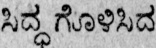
ಸಿದ್ಧಗೊಳಿಸಿದ
